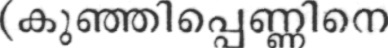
(കുഞ്ഞിപ്പെണ്ണിനെ
